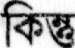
কিন্তু
